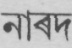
নাৰদ
